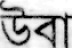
উবা
